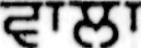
ਵਾਲਾ
